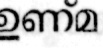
ഉണ്മ
